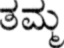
ತಮ್ಮ
